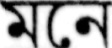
মনে
